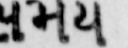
સમય
